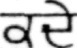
ਕਦੇ
